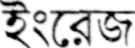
ইংরেজ
